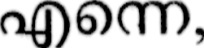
എന്നെ,
